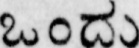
ಒಂದು
